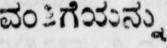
ವಂತಿಗೆಯನ್ನು
